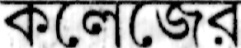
কলেজের
